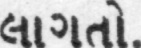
લાગતો.
